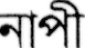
নাপী
